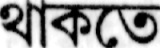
থাকতে
